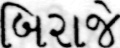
બિરાજે
